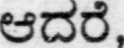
ಆದರೆ,
